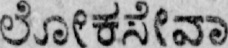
ಲೋಕಸೇವಾ
